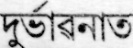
দুর্ভাৱনাত
